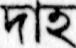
দাহ
